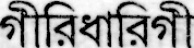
গীরিধারিগী
